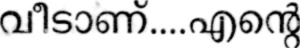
വീടാണ്..എന്റെ
